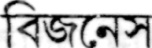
বিজনেস
